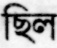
ছিল
